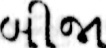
બીજા
